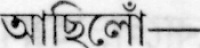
আছিলোঁ-
